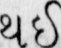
થઈ
